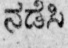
ನಡೆಸಿ
